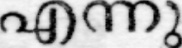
എന്നു
